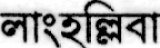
লাংহল্লিবা
